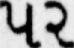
પર
